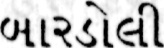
બારડોલી
